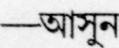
–আসুন
